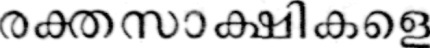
രക്തസാക്ഷികളെ
